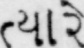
ત્યારે
